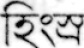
হিংস্র
